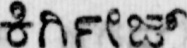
ಕಿರ್ಗೀಜ್
